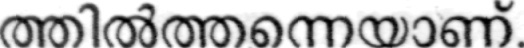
ത്തില്‍ത്തന്നെയാണ്.
